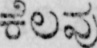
ಕೆಲವು
